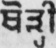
ਥੋੜ੍ਹੀ
